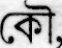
কৌ,
